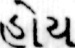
હોય
